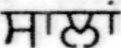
ਸਾਲਾਂ
